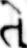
તે
